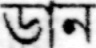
ডান
